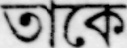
তাকে
